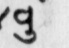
જવું
